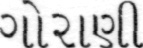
ગોરાણી
